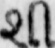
શી
